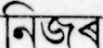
নিজৰ
